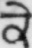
ਕੇ
